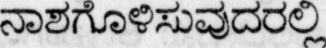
ನಾಶಗೊಳಿಸುವುದರಲ್ಲಿ
